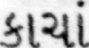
કાચાં
